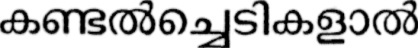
കണ്ടല്‍ച്ചെടികളാല്‍
